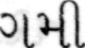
ગમી
